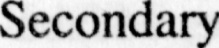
Secondary
